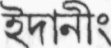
ইদানীং
